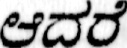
ಆದರೆ
